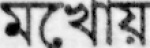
মখোয়
